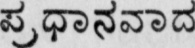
ಪ್ರಧಾನವಾದ
